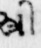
સ્ત્રી
